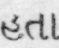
હતા
